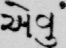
એવું
